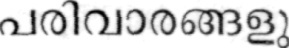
പരിവാരങ്ങളു
